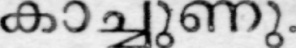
കാച്ചുണു.
